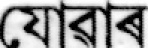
যোৱাৰ
